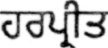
ਹਰਪ੍ਰੀਤ
